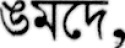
ঙমদে,
